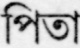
পিতা
